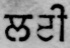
ਲਈ
